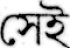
সেই
